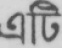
এটি
